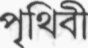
পৃথিবী
